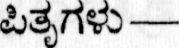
ಪಿತೃಗಳು-
